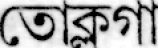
তোক্লগা
